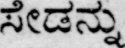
ಸೇಡನ್ನು
